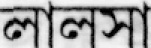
লালসা
